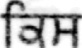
ਕਿਸ
